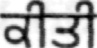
ਕੀਤੀ
